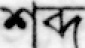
শব্দ
